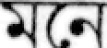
মনে
